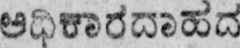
ಅಧಿಕಾರದಾಹದ
